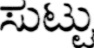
ಸುಟ್ಟು
